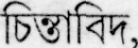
চিন্তাবিদ,
